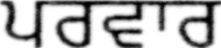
ਪਰਵਾਰ
